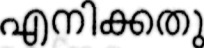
എനിക്കതു
